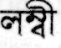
লম্বী
